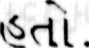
હતો.
